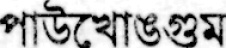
পাউখোঙগুম
